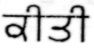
ਕੀਤੀ
